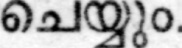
ചെയ്യും.
